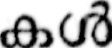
കള്‍
